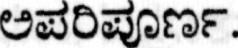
ಅಪರಿಪೂರ್ಣ.
